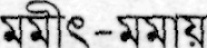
মমীৎ-মমায়
